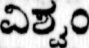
ವಿಶ್ವಂ
